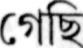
গেছি
